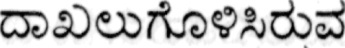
ದಾಖಲುಗೊಳಿಸಿರುವ
